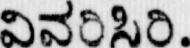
ವಿವರಿಸಿರಿ.
